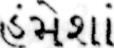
હંમેશાં
